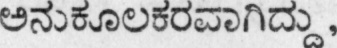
ಅನುಕೂಲಕರವಾಗಿದ್ದು,
